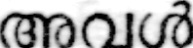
അവള്‍
